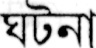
ঘটনা
